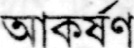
আকর্ষণ
